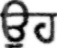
ਉਹ
